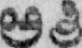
ಅತಿ
